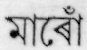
মাৰোঁ
